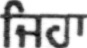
ਜਿਹਾ
